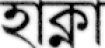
হাক্না
